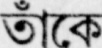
তাঁকে
